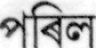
পৰিল
